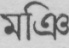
মঞি
